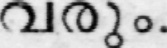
വരും.
